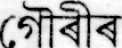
গৌৰীৰ
